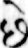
છે
